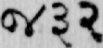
જરૂર
